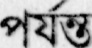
পর্যন্ত
